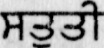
ਸਤੁਤੀ
